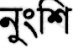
নুংশি
